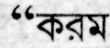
“করম
